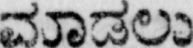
ಮಾಡಲು
